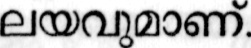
ലയവുമാണ്.
